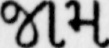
જામ
